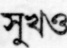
সুখও
